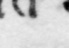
રીતે
